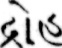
દ્રોહ
